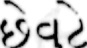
છેવટે
